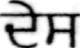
ਦੇਸ
